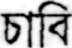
চাবি
